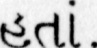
હતાં.
